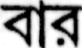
বার
